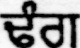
ਢੰਗ
